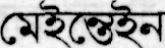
মেইন্তেইন
